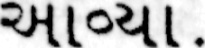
આવ્યા.
